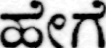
ಹೇಗೆ
